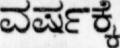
ವರ್ಷಕ್ಕೆ
